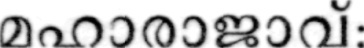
മഹാരാജാവ്:
